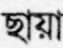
ছায়া
